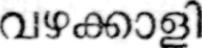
വഴക്കാളി
